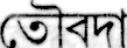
তৌবদা
